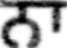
ਨਾ
